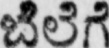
ಬೆಲೆಗೆ
